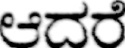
ಆದರೆ
